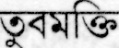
তুবমক্তি
